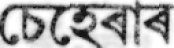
চেহেৰাৰ
